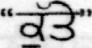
''ਕੁੱਤੇ''
